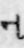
ન
